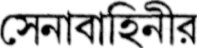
সেনাবাহিনীর
